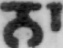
ਨਾ
